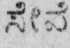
ಸೇವೆ
